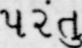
પરંતુ
